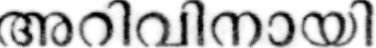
അറിവിനായി
